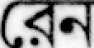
রেন
